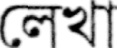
লেখা
